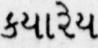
ક્યારેય
